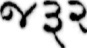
જરૂર
